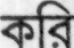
করি
